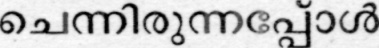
ചെന്നിരുന്നപ്പോള്‍
